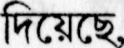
দিয়েছে,
